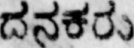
ದನಕರು
